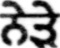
ਨੇੜੇ
